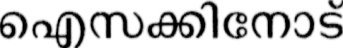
ഐസക്കിനോട്
